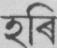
হৰি
